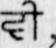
ਵੀ,
